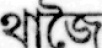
থাজৈ
